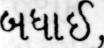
બધાઈ,
